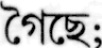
গৈছে;
